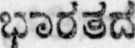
ಭಾರತದ
